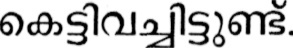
കെട്ടിവച്ചിട്ടുണ്ട്.
